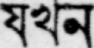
যখন
